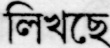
লিখছে
